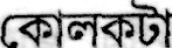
কোলকটা
